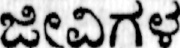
ಜೀವಿಗಳ
